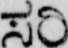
ಸರಿ
